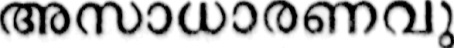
അസാധാരണവു
